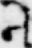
ને
